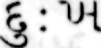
દુઃખ
